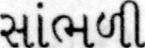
સાંભળી
